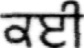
ਕਈ
